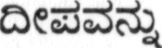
ದೀಪವನ್ನು
